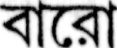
বারো
